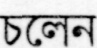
চলেন
